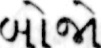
બોજો
